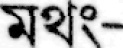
মথং-
